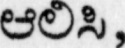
ಆಲಿಸಿ,
